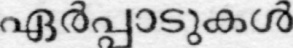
ഏര്‍പ്പാടുകള്‍
